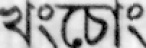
খংচোং
